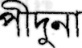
পীদুনা
